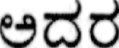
ಅದರ
